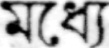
মধ্যে
